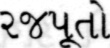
રજપૂતો
